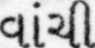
વાંચી
